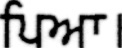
ਪਿਆ।
